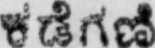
ಕಡೆಗಣಿ
